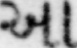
આ
